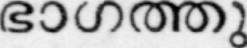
ഭാഗത്തു
